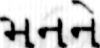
મનને
